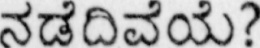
ನಡೆದಿವೆಯೆ?
